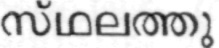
സ്ഥലത്തു
